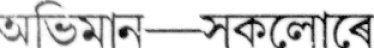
অভিমান-সকলোৰে
